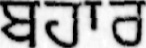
ਬਹਾਰ
